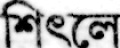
শিৎলে
